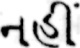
નહીં
